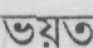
ভয়ত
